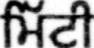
ਮਿੱਟੀ
